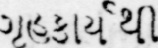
ગૃહકાર્યથી
